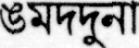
ঙমদদুনা
